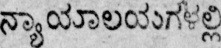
ನ್ಯಾಯಾಲಯಗಳಲ್ಲಿ
